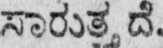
ಸಾರುತ್ತದೆ.
